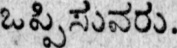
ಒಪ್ಪಿಸುವರು.
